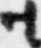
ન
